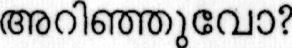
അറിഞ്ഞുവോ?
